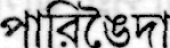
পারিঙৈদা
